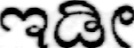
ಇಡೀ
